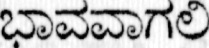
ಭಾವವಾಗಲಿ
